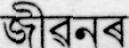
জীৱনৰ
